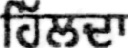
ਹਿੱਲਦਾ
